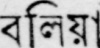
বলিয়া
